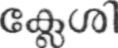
ക്ലേശി
